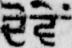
ਦੋਵੇਂ
